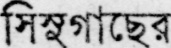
সিসুগাছের
